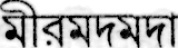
মীরমদমদা
